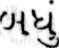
બધું
